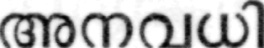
അനവധി
